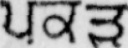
ਪਕੜ
